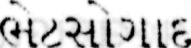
ભેટસોગાદ
